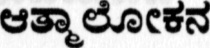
ಆತ್ಮಾಲೋಕನ
